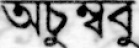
অচুম্ববু
